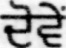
ਦੋਵੇਂ
